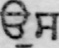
ਉਸ
